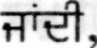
ਜਾਂਦੀ,
